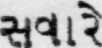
સુવારે
